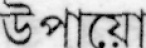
উপায়ো
